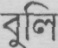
বুলি
